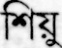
শিয়ু
